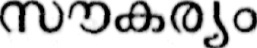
സൌകര്യം
